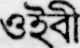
ওইবী
